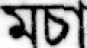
মচা
